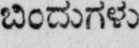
ಬಿಂದುಗಳು
